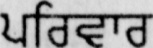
ਪਰਿਵਾਰ
